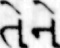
તેને
